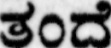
ತಂದೆ
